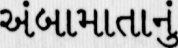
અંબામાતાનું
